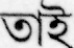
তাই
